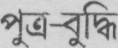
পুত্ৰ-বুদ্ধি
